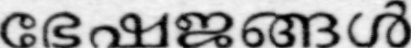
ഭേഷജങ്ങള്‍
